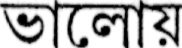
ভালোয়
